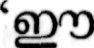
‘ഈ
